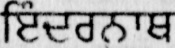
ਇੰਦਰਨਾਥ
